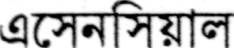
এসেনসিয়াল
